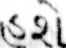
હશે
